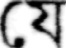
যে
